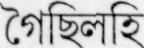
গৈছিলহি
